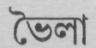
ভৈলা
